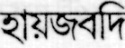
হায়জবদি
